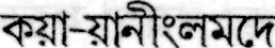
কয়া-য়ানীংলমদে
